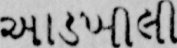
આડખીલી
